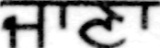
ਜਾਣਾ
